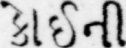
કોઈની
